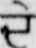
ਦੇ
